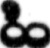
ಹಿ
